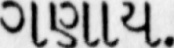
ગણાય.
